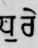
ਧੁਰੇ
